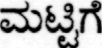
ಮಟ್ಟಿಗೆ
